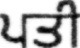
ਪਤੀ
